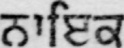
ਨਾਇਕ
